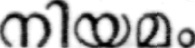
നിയമം
